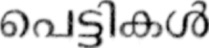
പെട്ടികള്‍
